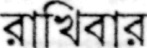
রাখিবার
